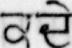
ਕਦੇ
